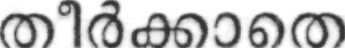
തീര്‍ക്കാതെ
